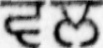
ਵਲ
